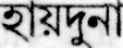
হায়দুনা
